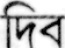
দিব
